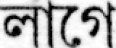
লাগে
